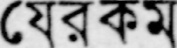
যেরকম
